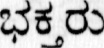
ಭಕ್ತರು
